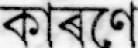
কাৰণে
